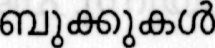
ബുക്കുകള്‍
